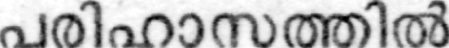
പരിഹാസത്തില്‍
